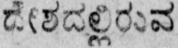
ದೇಶದಲ್ಲಿರುವ
